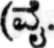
(ವೈ.
